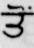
ਤੋਂ
